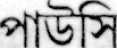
পাউসি
